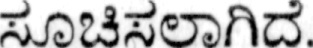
ಸೂಚಿಸಲಾಗಿದೆ.
